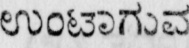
ಉಂಟಾಗುವ
